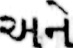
અને
